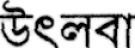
উৎলবা
